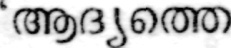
‘ആദ്യത്തെ
